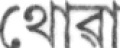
থোৱা
